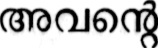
അവന്റെ
